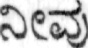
ನೀವು
